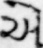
એ
